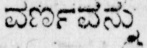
ವರ್ಣವನ್ನು
